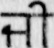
ਜੀ
